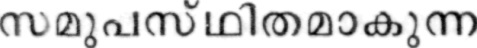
സമുപസ്ഥിതമാകുന്ന
